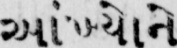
આંખ્યોને
